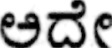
ಅದೇ
